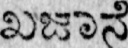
ಖಜಾನೆ
